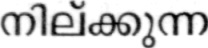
നില്ക്കുന്ന
